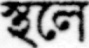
স্থলে
